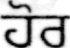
ਹੋਰ
